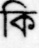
কি
